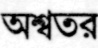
অশ্বতর
